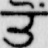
ਤੋਂ
